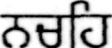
ਨਚਹਿ
